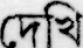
দেখি
